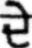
ਦੇ
